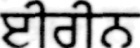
ਈਰੀਨ
